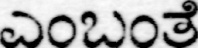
ಎಂಬಂತೆ
